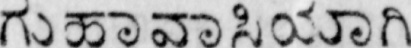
ಗುಹಾವಾಸಿಯಾಗಿ
